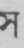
স
